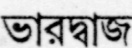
ভারদ্বাজ
